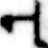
ન
